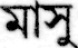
মাসু
